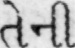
તેની
